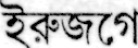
ইরুজগে
